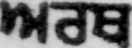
ਅਰਥ
